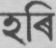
হৰি
